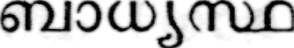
ബാധ്യസ്ഥ
